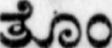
ತೊಂ
